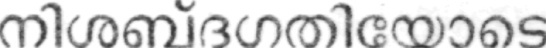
നിശബ്ദഗതിയോടെ
